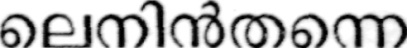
ലെനിന്‍തന്നെ
